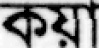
কয়া
